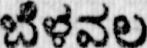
ಬೆಳವಲ
